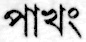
পাখং
